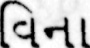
વિના
